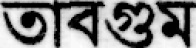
তাবগুম
